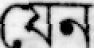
যেন
